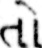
તો
